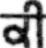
ਕੀ
